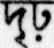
দৃঢ়
